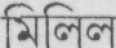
মিলিল
